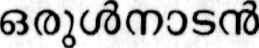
ഒരുള്‍നാടന്‍
